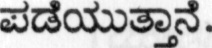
ಪಡೆಯುತ್ತಾನೆ.
